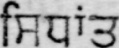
ਸਿਧਾਂਤ
